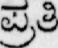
ಪ್ರತಿ
